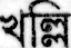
খল্লি
